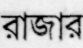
রাজার
